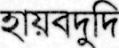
হায়বদুদি
